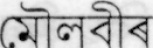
মৌলবীৰ
